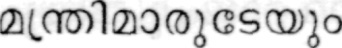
മന്ത്രിമാരുടേയും
